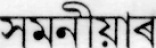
সমনীয়াৰ
